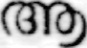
ആ
